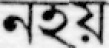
নহয়
